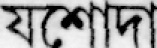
যশোদা
